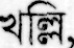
খল্লি,
